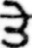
ਤੇ
